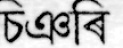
চিঞৰি
